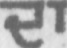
ਦਾ
